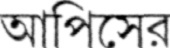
আপিসের
